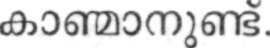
കാണ്മാനുണ്ട്.
